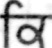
ਕਿ
